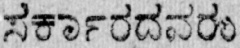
ಸರ್ಕಾರದವರು
